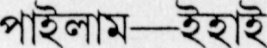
পাইলাম-ইহাই
